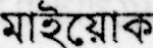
মাইয়োক
